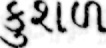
કુશળ
